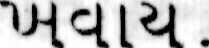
ખવાય.
